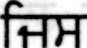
ਜਿਸ
